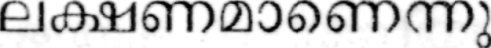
ലക്ഷണമാണെന്നു
